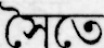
সৈতে
